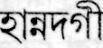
হান্নদগী
